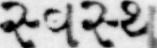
સ્વસ્થ
